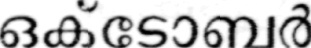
ഒക്ടോബര്‍
